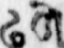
ઢળે
